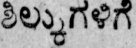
ಶಿಲ್ಕುಗಳಿಗೆ
